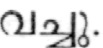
വച്ചു.
